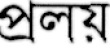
প্রলয়
